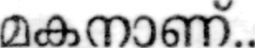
മകനാണ്..
